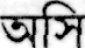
অসি
